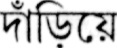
দাঁড়িয়ে
